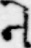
ને
